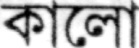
কালো
